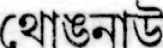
থোঙনাউ
